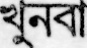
খুনবা
